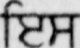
ਇਸ
